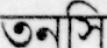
তনসি
